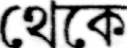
থেকে
